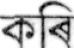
কৰি
